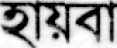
হায়বা
